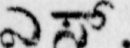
ಎಸ್.
